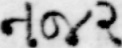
નજર
